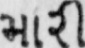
મારી
